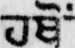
ਹਥੋਂ
